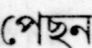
পেছন
